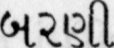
બરણી
